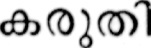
കരുതി
